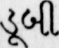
ડૂબી
